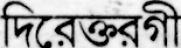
দিরেক্তরগী
